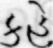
કહે
